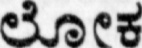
ಲೋಕ
